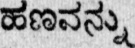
ಹಣವನ್ನು
